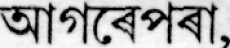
আগৰেপৰা,
